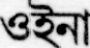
ওইনা
